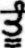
ਤੂੰ
